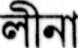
লীনা
